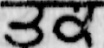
ਤਕ
